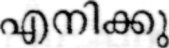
എനിക്കു
